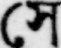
সে
